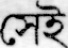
সেই
